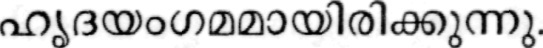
ഹൃദയംഗമമായിരിക്കുന്നു.
